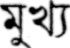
মুখ্য
